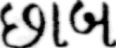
છાબ
